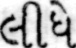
લીધે
